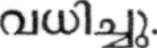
വധിച്ചു.
